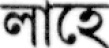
লাহে
